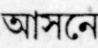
আসনে
